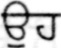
ਉਹ
